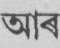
আৰ
